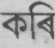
কৰি
